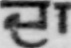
ਦਾ
